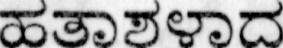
ಹತಾಶಳಾದ
